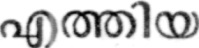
എത്തിയ
